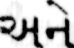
અને
